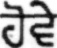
ਹੋਵੇ
